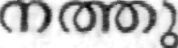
നത്തു
